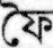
ফৈ
